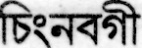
চিংনবগী
